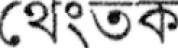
থেংতক
